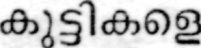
കുട്ടികളെ
